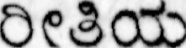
ರೀತಿಯ
